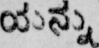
ಯನ್ನು
